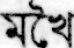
মখৈ
